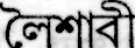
লৈশাবী
